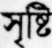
সৃষ্টি
